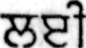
ਲਈ
